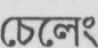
চেলেং
